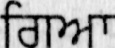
ਗਿਆ
